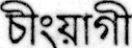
চীংয়াগী
